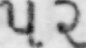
પર
